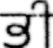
ਭੀ
